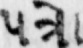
પત્રો
